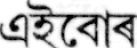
এইবোৰ
